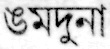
ঙমদুনা
